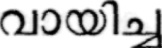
വായിച്ച
